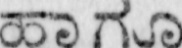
ಹಾಗೂ
